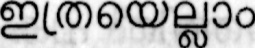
ഇത്രയെല്ലാം
